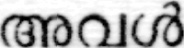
അവള്‍
